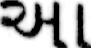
આ
